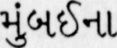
મુંબઈના
